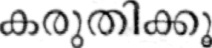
കരുതിക്കൂ
